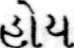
હોય
